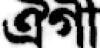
ঐগী
